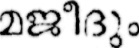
മജീദും
